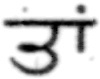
ਤਾਂ
